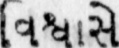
વિશ્વાસે
